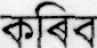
কৰিব
